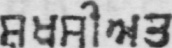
ਸ਼ਖਸੀਅਤ
